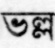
ভল্ল
